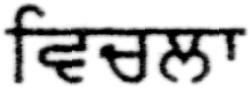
ਵਿਚਲਾ
